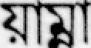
য়াম্না
